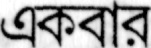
একবার
